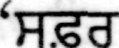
'ਸਫ਼ਰ
